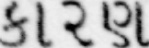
કારણ
